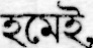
হমেই,
